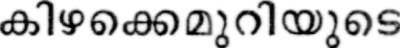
കിഴക്കെമുറിയുടെ
